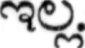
ಇಲ್ಲ.
